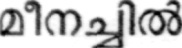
മീനച്ചില്‍
